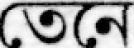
তেনে
